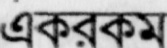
একরকম
